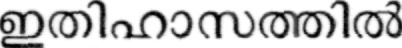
ഇതിഹാസത്തില്‍
